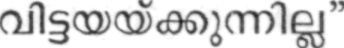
വിട്ടയയ്ക്കുന്നില്ല”
